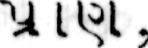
પ્રાણ,
